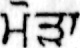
ਮੋੜਾ
